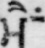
ਮੈਂ
